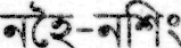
নহৈ-নশিং
